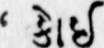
'કોઈ
